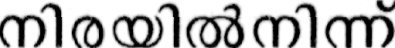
നിരയില്‍നിന്ന്
